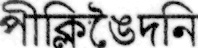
পীক্লিঙৈদনি
